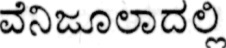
ವೆನಿಜೂಲಾದಲ್ಲಿ
